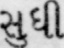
સુધી
